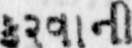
કરવાની
